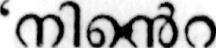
‘നിന്റെ
